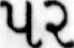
પર
